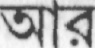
আর
